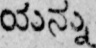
ಯನ್ನು
